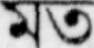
মত
